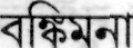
বঙ্কিমনা
